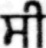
ਸੀ
